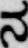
ನ
